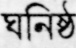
ঘনিষ্ঠ
